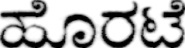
ಹೊರಟೆ
